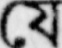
যে
